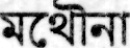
মথৌনা
